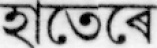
হাতেৰে
